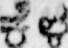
ಕೆಳ
